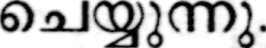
ചെയ്യുന്നു.
